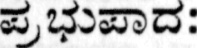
ಪ್ರಭುಪಾದ:
